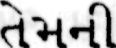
તેમની
